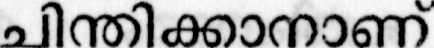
ചിന്തിക്കാനാണ്
